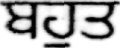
ਬਹੁਤ
